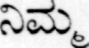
ನಿಮ್ಮ
